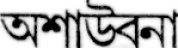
অশাউবনা
